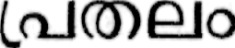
പ്രതലം
